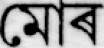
মোৰ
